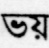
ভয়
